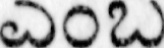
ಎಂಬ
